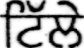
ਟਿੱਲੇ
